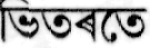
ভিতৰতে
